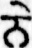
ਨੇ
